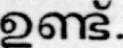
ഉണ്ട്.
